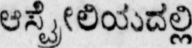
ಆಸ್ಟ್ರೇಲಿಯದಲ್ಲಿ
